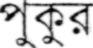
পুকুর
